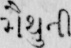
મૈથુની
